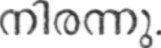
നിരന്നു.
